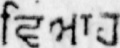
ਵਿਆਹ
